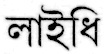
লাইধি
